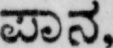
ಪಾನ,
